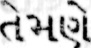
તેમણે
